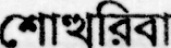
শোত্থরিবা
